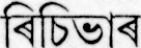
ৰিচিভাৰ
